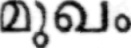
മുഖം
